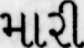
મારી
